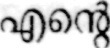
എന്റെ
